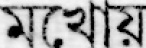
মখোয়
